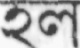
হল
